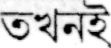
তখনই
